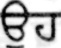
ਉਹ
